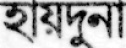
হায়দুনা
